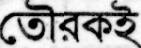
তৌরকই
